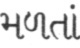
મળતા
